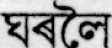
ঘৰলৈ
